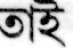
তাই
